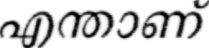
എന്താണ്
